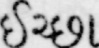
ઈચ્છા
